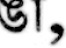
ঙা,
